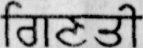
ਗਿਣਤੀ
